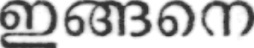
ഇങ്ങനെ
